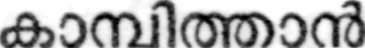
കാമ്പിത്താന്‍
